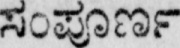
ಸಂಪೂರ್ಣ
